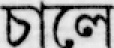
চালে
